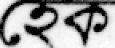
হেক
